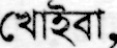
খোইবা,
